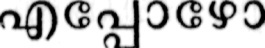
എപ്പോഴോ
